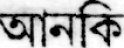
আনকি
